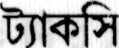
ট্যাকসি
